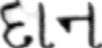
દાન
